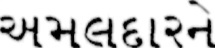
અમલદારને
